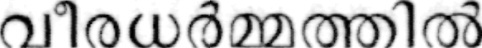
വീരധര്‍മ്മത്തില്‍
